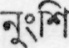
নুংশি
